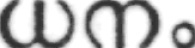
ധനം
